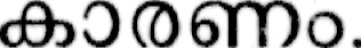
കാരണം.
